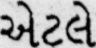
એટલે
